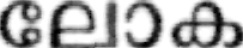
ലോക
